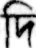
দি
